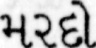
મરદો
